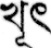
খূৎ
